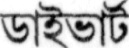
ডাইভার্ট
